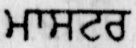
ਮਾਸਟਰ
